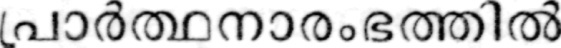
പ്രാര്‍ത്ഥനാരംഭത്തില്‍
